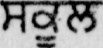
ਸਕੂਲ
